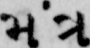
મંત્ર
